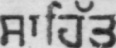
ਸਾਹਿੱਤ
